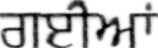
ਗਈਆਂ
